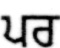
ਪਰ
